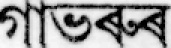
গাভৰুৰ
